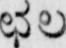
ಛಲ
